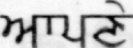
ਆਪਣੇ
